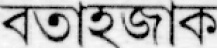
বতাহজাক
